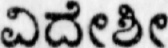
ವಿದೇಶೀ
